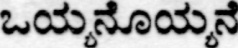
ಒಯ್ಯನೊಯ್ಯನೆ
